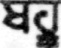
ਬਹੂ
